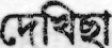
দেখিছা
